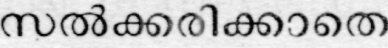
സല്‍ക്കരിക്കാതെ
